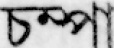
চম্পা
